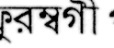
ফুরম্বগী
